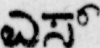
ಎಸ್
